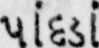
પાંદડાં
